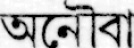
অনৌবা
